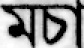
মচা
